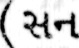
(સન
